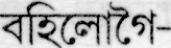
বহিলোগৈ-
